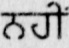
ਨਹੀਂ
